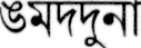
ঙমদদুনা
